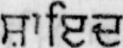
ਸ਼ਾਇਦ
